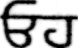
ਓਹ
